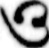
ও
